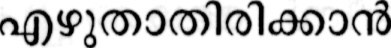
എഴുതാതിരിക്കാന്‍
